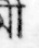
মী
